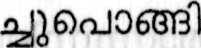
ച്ചുപൊങ്ങി
